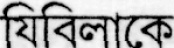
যিবিলাকে
